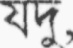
যদু,
